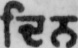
ਦਿਨ
